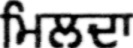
ਮਿਲਦਾ
